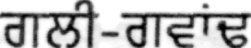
ਗਲੀ-ਗਵਾਂਢ
